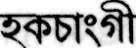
হকচাংগী
